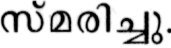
സ്മരിച്ചു.
